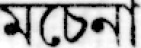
মচেনা
